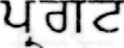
ਪ੍ਰਗਟ
